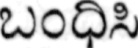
ಬಂಧಿಸಿ
